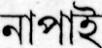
নাপাই
